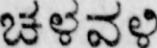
ಚಳವಳಿ
